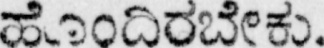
ಹೊಂದಿರಬೇಕು.
